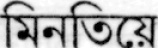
মিনতিয়ে
